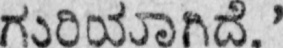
ಗುರಿಯಾಗಿದೆ’.
